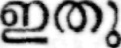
ഇതു
